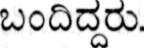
ಬಂದಿದ್ದರು.
